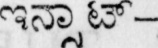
ಇನ್ಸಾಟ್-
